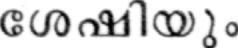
ശേഷിയും
